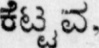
ಕೆಟ್ಟವ,
